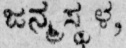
ಜನ್ಮಸ್ಥಳ,
